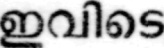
ഇവിടെ
